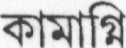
কামাগ্নি
